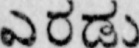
ಎರಡು
